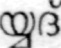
യ്യദ്
